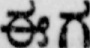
ಈಗ
